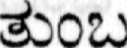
ತುಂಬ
